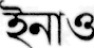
ইনাও
